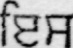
ਇਸ
